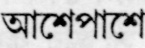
আশেপাশে
